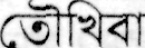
তৌখিবা
